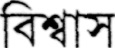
বিশ্বাস
